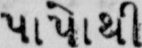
પાપોથી
